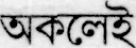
অকলেই
